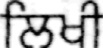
ਲਿਖੀ
